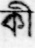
কী
